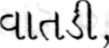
વાતડી,
